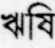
ঋষি
